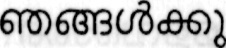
ഞങ്ങള്‍ക്കു
